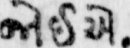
જોઈએ.
